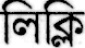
লিক্লি
